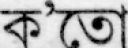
ক'তো
